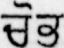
ਚੋਭ
